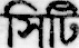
সিটি
